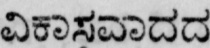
ವಿಕಾಸವಾದದ
